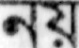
নয়
